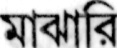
মাঝারি
